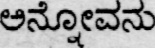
ಅನ್ನೋವನು
